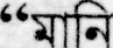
“মানি
